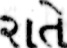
રાતે
